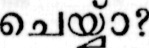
ചെയ്യാ?
